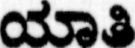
ಯಾತಿ
